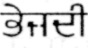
ਭੇਜਦੀ
